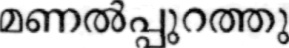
മണല്‍പ്പുറത്തു
